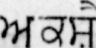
ਅਕਸ਼ੈ
